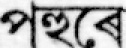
পহুৰে
